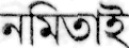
নমিতাই
